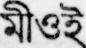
মীওই
